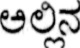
ಅಲ್ಲಿನ
